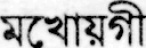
মখোয়গী
